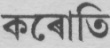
কৰোতি
